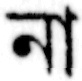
না
